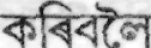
কৰিবলৈ
